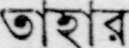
তাহার
